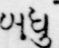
બધું
